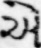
એ
